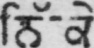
ਨਿੱਕੇ
